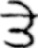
ਤੇ
